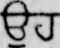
ਉਹ
